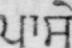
ਪਾਸੇ
